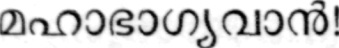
മഹാഭാഗ്യവാന്‍!
